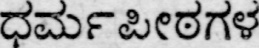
ಧರ್ಮಪೀಠಗಳ
